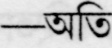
–অতি
